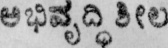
ಅಭಿವೃದ್ಧಿಶೀಲ
